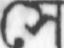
সে
